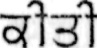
ਕੀਤੀ
